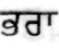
ਭਰਾ
